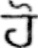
ਹੋ
